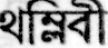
থম্লিবী
